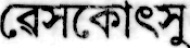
ৱেসকোৎসু
